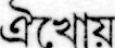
ঐখোয়
